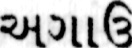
અગાઉ
